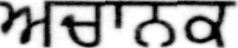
ਅਚਾਨਕ
